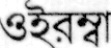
ওইরম্বা
